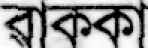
ৱাককা
